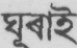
ঘূৰাই
